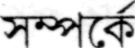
সম্পর্কে
